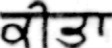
ਕੀਤਾ
